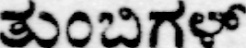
ತುಂಬಿಗಳ್
